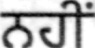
ਨਹੀਂ
